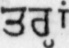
ਤਰ੍ਹਾਂ
